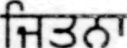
ਜਿਤਨਾ
